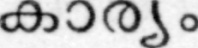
കാര്യം
